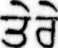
ਤੇਰੇ
